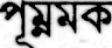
পূম্নমক
